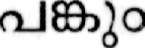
പങ്കും
